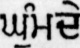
ਘੁੰਮਦੇ
